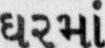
ઘરમાં
